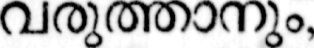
വരുത്താനും,
